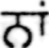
ਨਾਂ
